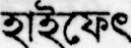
হাইফেৎ
